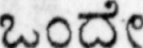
ಒಂದೇ
